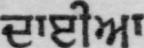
ਦਾਈਆ
